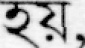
হয়,
